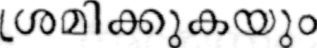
ശ്രമിക്കുകയും
